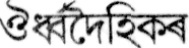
ঔৰ্ধ্বদৈহিকৰ
